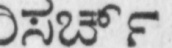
ರಿಸರ್ಚ್
